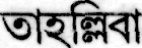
তাহল্লিবা
